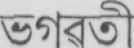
ভগৱতী
